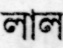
লাল
